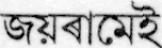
জয়ৰামেই
